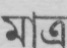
মাত্ৰ
